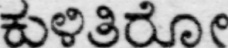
ಕುಳಿತಿರೋ
